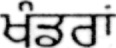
ਖੰਡਰਾਂ
